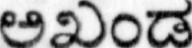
ಅಖಂಡ
